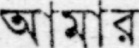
আমার
